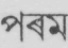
পৰম
